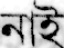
নাই
